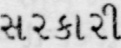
સરકારી
